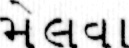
મેલવા
